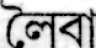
লৈবা
